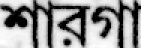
শারগা
